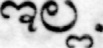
ಇಲ್ಲ.
